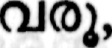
വരൂ,
